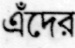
এঁদের
